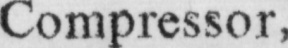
Compressor,
